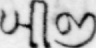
બીજી
